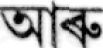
আৰু
